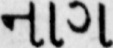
નાગ
